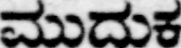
ಮುದುಕ
